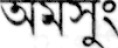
অমসুং
